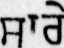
ਸਾਰੇ
